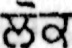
ਲੋਕ
